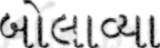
બોલાવ્યા
